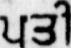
ਪਤੀ
